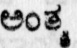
ಅಂತ್ಯ
